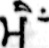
ਮੈਂ
